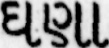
ઘણા
